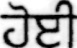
ਹੋਈ
